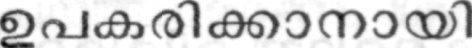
ഉപകരിക്കാനായി
